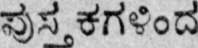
ಪುಸ್ತಕಗಳಿಂದ
